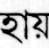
হায়
